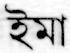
ঐমা
